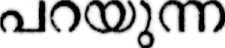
പറയുന്ന
